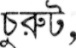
চুরুট,
